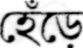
হেঁড়ে
